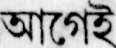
আগেই
